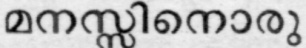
മനസ്സിനൊരു
